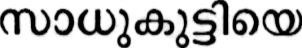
സാധുകുട്ടിയെ
